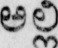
ಅಲ್ಲಿ
